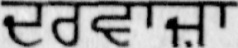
ਦਰਵਾਜ਼ਾ
